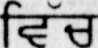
ਵਿੱਚ
